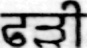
ਫੜੀ
